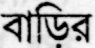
বাড়ির
